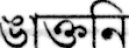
ঙাক্তনি
